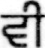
ਵੀ
